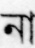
না
